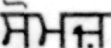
ਸੋਮਜ਼
